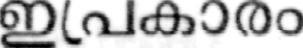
ഇപ്രകാരം
